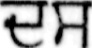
ਦਸ
